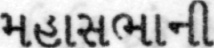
મહાસભાની
